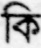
কি
